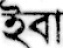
ইবা
